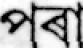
পৰা
